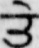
ਤੇ
